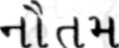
નૌતમ
